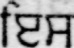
ਇਸ
